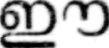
ഈ
